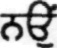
ਨਉਂ
